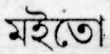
মইতো
